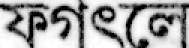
ফগৎলে
